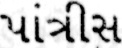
પાંત્રીસ
